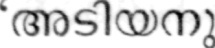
'അടിയനു
